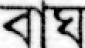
বাঘ
